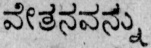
ವೇತನವನ್ನು
